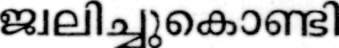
ജ്വലിച്ചുകൊണ്ടി
